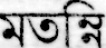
মতম্নি
